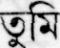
তুমি
